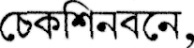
চেকশিনবনে,
